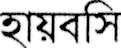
হায়বসি
